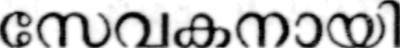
സേവകനായി
